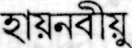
হায়নবীয়ু
